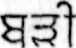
ਬੜੀ
